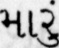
મારું
